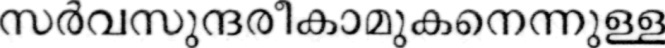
സര്‍വസുന്ദരീകാമുകനെന്നുള്ള
